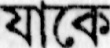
যাকে
